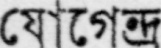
যোগেন্দ্র
